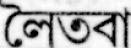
লৈতবা
